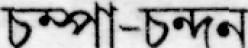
চম্পা-চন্দন
